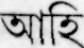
আহি
